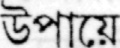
উপায়ে
